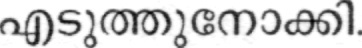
എടുത്തുനോക്കി.
